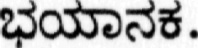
ಭಯಾನಕ.
